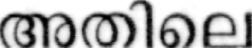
അതിലെ
